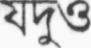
যদুও
